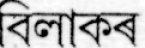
বিলাকৰ
